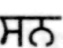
ਸਨ
